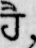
ਹੈ,
